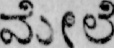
ಮೇಲೆ
